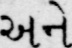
અને
